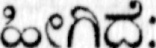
ಹೀಗಿದೆ:
